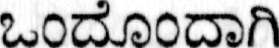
ಒಂದೊಂದಾಗಿ
